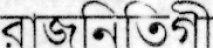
রাজনিতিগী
